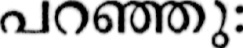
പറഞ്ഞു:
